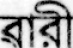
ৱারী
